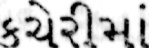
કચેરીમાં
